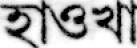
হাওখা
